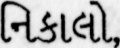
નિકાલો,
